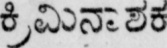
ಕ್ರಿಮಿನಾಶಕ
